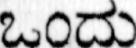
ಒಂದು
